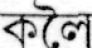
কলৈ
